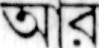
আর
